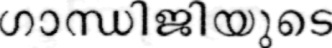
ഗാന്ധിജിയുടെ
